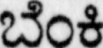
ಬೆಂಕಿ
